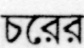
চরের
